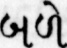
બળે
